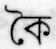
কৈ
